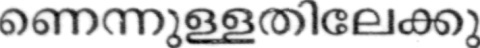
ണെന്നുള്ളതിലേക്കു
